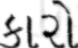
કારો
